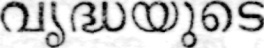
വൃദ്ധയുടെ
